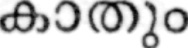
കാതും
